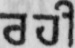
ਰਹੀ
